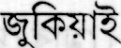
জুকিয়াই
